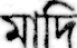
মাদি
